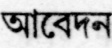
আবেদন
